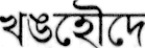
খঙহৌদে
